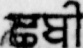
ਛਬੀ
